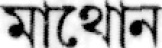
মাথোন
